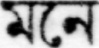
মনে
